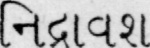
નિદ્રાવશ
